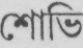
শোভি
